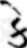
કે
